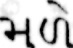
મળે
